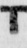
T
